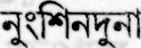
নুংশিনদুনা
